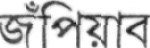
জঁপিয়াব
